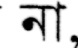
না,
